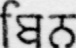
ਬਿਨ
